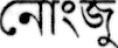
নোংজু
